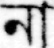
না
